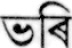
ভৰি
